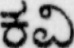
ಕವಿ
